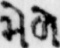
મેળે
